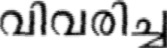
വിവരിച്ച
